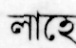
লাহে
